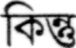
কিন্তু
